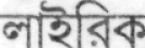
লাইরিক
